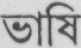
ভাষি
